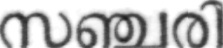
സഞ്ചരി
